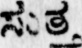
ಸುತ್ತ
